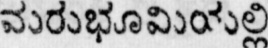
ಮರುಭೂಮಿಯಲ್ಲಿ
